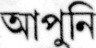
আপুনি
